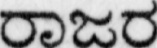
ರಾಜರ
